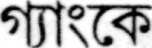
গ্যাংকে
